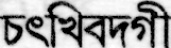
চৎখিবদগী
